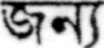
জন্য
